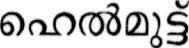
ഹെല്‍മുട്ട്
